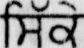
ਸਿੱਕੇ
